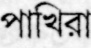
পাখিরা
